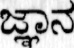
ಜ್ಞಾನ
